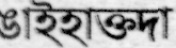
ঙাইহাক্তদা
